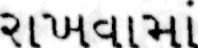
રાખવામાં
